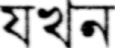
যখন
